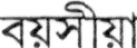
বয়সীয়া
